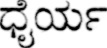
ಧೈರ್ಯ
